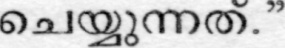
ചെയ്യുന്നത്."
